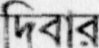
দিবার
